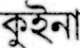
কুইনা
